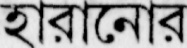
হারানোর
